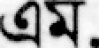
এম.
